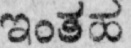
ಇಂತಹ
